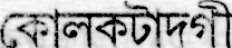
কোলকটাদগী
